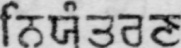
ਨਿਯੰਤਰਣ
